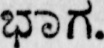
ಭಾಗ.
